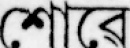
শোৱে
